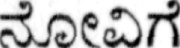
ನೋವಿಗೆ
